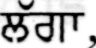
ਲੱਗਾ,
